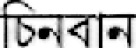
চিনবান
